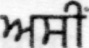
ਅਸੀਂ
